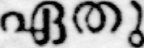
ഏതു
